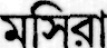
মসিরা
